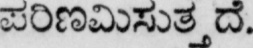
ಪರಿಣಮಿಸುತ್ತದೆ.
